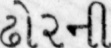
ઢોરની
